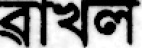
ৱাখল
